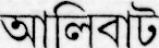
আলিবাট
